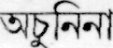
অচুনিনা
